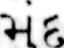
મંદ
